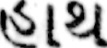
હાથ
